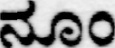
ನೂಂ
